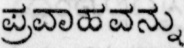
ಪ್ರವಾಹವನ್ನು
